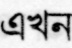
এখন
